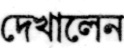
দেখালেন
